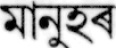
মানুহৰ
